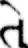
તે
